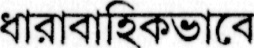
ধারাবাহিকভাবে
